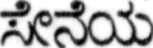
ಸೇನೆಯ
